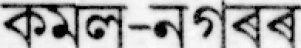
কমল-নগৰৰ
